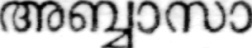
അബ്ബാസാ
